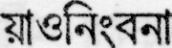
য়াওনিংবনা
